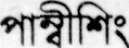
পাম্বীশিং
